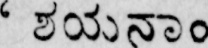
‘ಶಯನಾಂ
